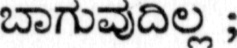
ಬಾಗುವುದಿಲ್ಲ;
